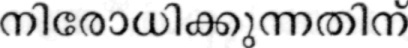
നിരോധിക്കുന്നതിന്
